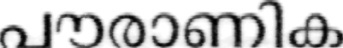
പൌരാണിക
